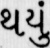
થયું
